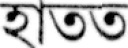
হাতত
